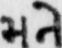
મને
